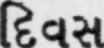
દિવસ
